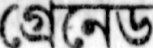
গ্রেনেড
